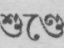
শুণ্ডে
